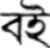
বই
